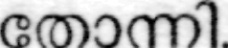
തോന്നി.
